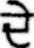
ਦੇ
